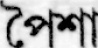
পৈশা
